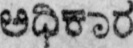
ಅಧಿಕಾರ
